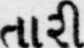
તારી
